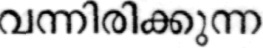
വന്നിരിക്കുന്ന
